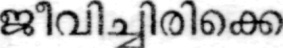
ജീവിച്ചിരിക്കെ
